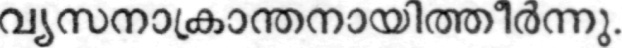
വ്യസനാക്രാന്തനായിത്തീര്‍ന്നു.
